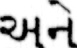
અને
